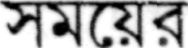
সময়ের
